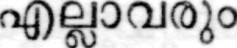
എല്ലാവരും
